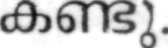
കണ്ടു.
